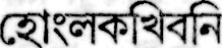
হোংলকখিবনি
